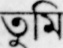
তুমি
